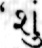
'શું
